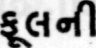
ફૂલની
